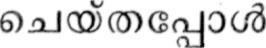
ചെയ്തപ്പോള്‍
